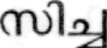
സിച്ച
